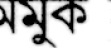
অমুক
